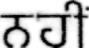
ਨਹੀਂ
